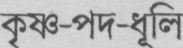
কৃষ্ণ-পদ-ধূলি
